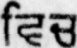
ਵਿਚ
